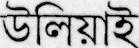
উলিয়াই
